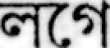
লগে
